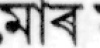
মোৰ
